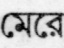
মেরে
